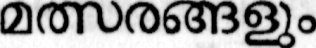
മത്സരങ്ങളും
